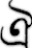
ঐ
